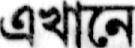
এখানে
